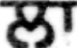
ਲਾ
